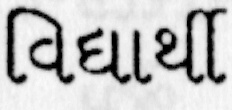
વિધાર્થી
